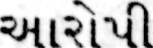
આરોપી
